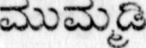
ಮುಮ್ಮಡಿ
